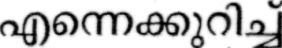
എന്നെക്കുറിച്ച്
